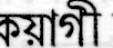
কয়াগী
